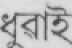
ধুৱাই
